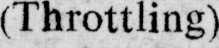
(Throttling)
